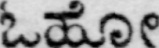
ಓಹೋ
